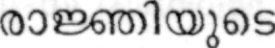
രാജ്ഞിയുടെ
